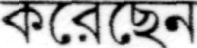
করেছেন
